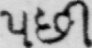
પછી
